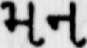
મન
